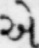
એ
